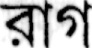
রাগ
